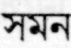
সমন
